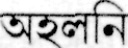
অহলনি
